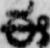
ಈ
